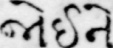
જોઈને
